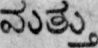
ಮತ್ತು
